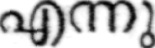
എന്നു
